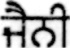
ਜੈਨੀ
